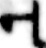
ન
